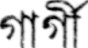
গার্গী
